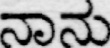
ನಾನು
